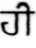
ਹੀ
